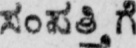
ಸಂಪತ್ತಿಗೆ
